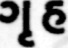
ગૃહ
